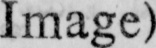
Image)
